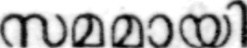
സമമായി
